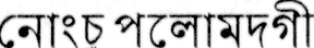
নোংচুপলোমদগী
